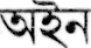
অইন
